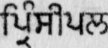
ਪ੍ਰਿੰਸੀਪਲ
